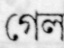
গেল
